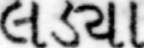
લડ્યા
